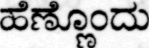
ಹೆಣ್ಣೊಂದು
